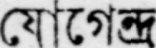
যোগেন্দ্র
